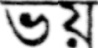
ভয়
